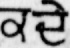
ਕਦੇ
